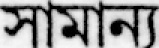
সামান্য
